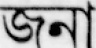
জনা
